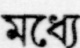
মধ্যে
